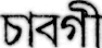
চাবগী
